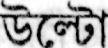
উল্টো
